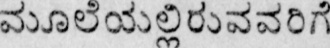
ಮೂಲೆಯಲ್ಲಿರುವವರಿಗೆ
